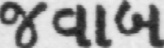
જવાબ
